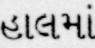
હાલમાં
